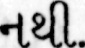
નથી.
